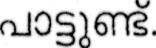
പാട്ടുണ്ട്.
